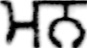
ਮਨ
